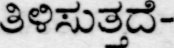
ತಿಳಿಸುತ್ತದೆ-
